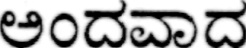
ಅಂದವಾದ
